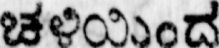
ಚಳಿಯಿಂದ
